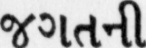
જગતની
